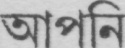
আপনি
